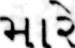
મારે
